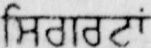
ਸਿਗਰਟਾਂ
